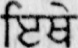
ਇਥੇ
